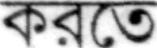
করতে
